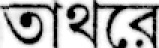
তাথরে
